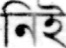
নিই
